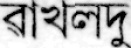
ৱাখলদু
